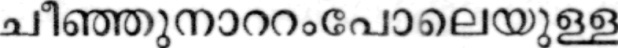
ചീഞ്ഞുനാററംപോലെയുള്ള
